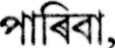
পাৰিবা,
